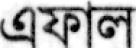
এফাল
